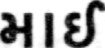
માઈ
